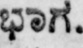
ಭಾಗ.
